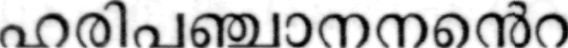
ഹരിപഞ്ചാനനന്റെ
